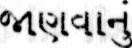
જાણવાનું
